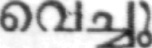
വെച്ചു
